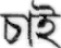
চাই
